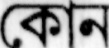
কোন
